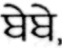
ਬੇਬੇ,
